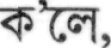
ক'লে,
